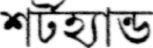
শর্টহ্যান্ড
